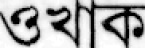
ওখাক
